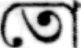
তো
